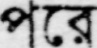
পরে
